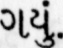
ગયું.
